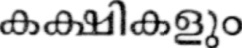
കക്ഷികളും
